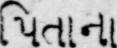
પિતાના
